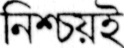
নিশ্চয়ই
